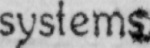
systems
